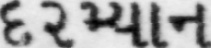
દરમ્યાન
